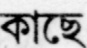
কাছে
